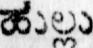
ಹುಲ್ಲು
